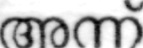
അന്ന്
